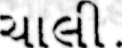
ચાલી.
